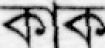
কাক
